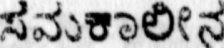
ಸಮಕಾಲೀನ
